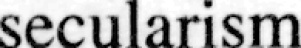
secularism
